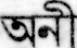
অনী
